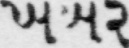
ખબર
